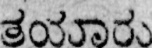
ತಯಾರು
